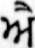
ਐ
